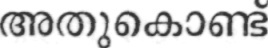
അതുകൊണ്ട്
